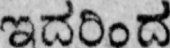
ಇದರಿಂದ
